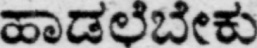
ಹಾಡಲೆಬೇಕು
